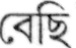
বেছি
